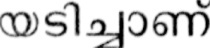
യടിച്ചാണ്
